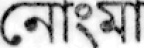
নোংমা
